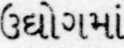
ઉદ્યોગમાં
